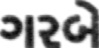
ગરબે
